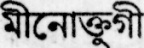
মীনোক্তুগী
